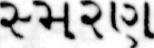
સ્મરણ
